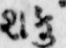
શકું
